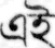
এই
